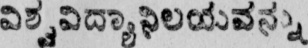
ವಿಶ್ವವಿದ್ಯಾನಿಲಯವನ್ನು
